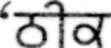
'ਠੀਕ
